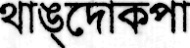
থাঙ্দোকপা
